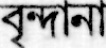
বৃন্দানা
